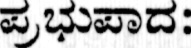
ಪ್ರಭುಪಾದ:
